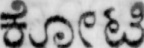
ಕೋಟಿ
